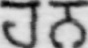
ਹਨ
